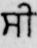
ਸੀ
